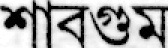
শাবগুম
